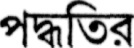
পদ্ধতির
